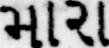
મારા
